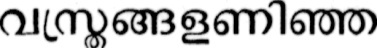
വസ്ത്രങ്ങളണിഞ്ഞ
